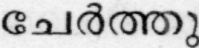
ചേര്‍ത്തു
